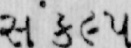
સંકલ્પ
